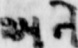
અને
